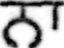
ਨਾ
